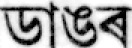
ডাঙৰ
